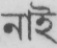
নাই
